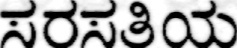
ಸರಸತಿಯ
